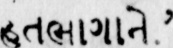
હતભાગને.'
